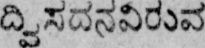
ದ್ವಿಸದನವಿರುವ
